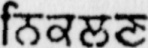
ਨਿਕਲਣ
